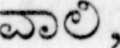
ವಾಲಿ,
